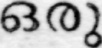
ഒരു
